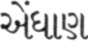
એંધાણ
